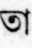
তা
